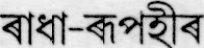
ৰাধা-ৰূপহীৰ
